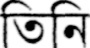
তিনি
